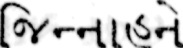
જિન્નાહને
